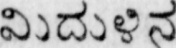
ಮಿದುಳಿನ
